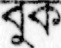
বুক
